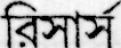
রিসার্স
